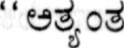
"ಅತ್ಯಂತ
